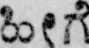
ಹೀಗೆ
